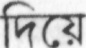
দিয়ে
